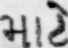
માટે
